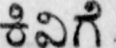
ಕಿವಿಗೆ
